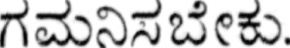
ಗಮನಿಸಬೇಕು.
